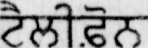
ਟੈਲੀਫ਼ੋਨ
